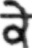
ਕੇ
